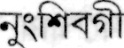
নুংশিবগী
